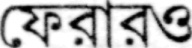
ফেরারও
